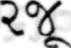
રજૂ
